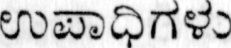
ಉಪಾಧಿಗಳು
